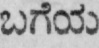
ಬಗೆಯ
